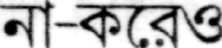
না-করেও
